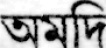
অমদি
